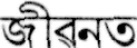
জীৱনত
